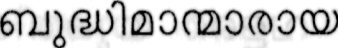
ബുദ്ധിമാന്മാരായ
